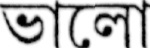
ভালো
